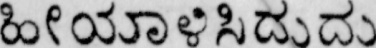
ಹೀಯಾಳಿಸಿದುದು
